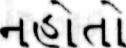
નહોતો
